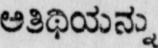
ಅತಿಥಿಯನ್ನು
